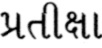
પ્રતીક્ષા
